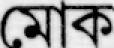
মোক
